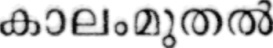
കാലംമുതല്‍
